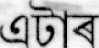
এটাৰ
